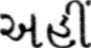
અહીં
